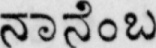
ನಾನೆಂಬ
